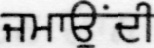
ਜਮਾਉਂਦੀ
